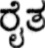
ರೈತ
